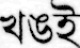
খঙই
